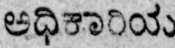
ಅಧಿಕಾರಿಯ
